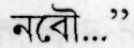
নবৌ..."
